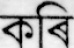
কৰি
